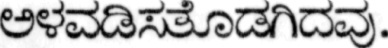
ಅಳವಡಿಸತೊಡಗಿದವು.
